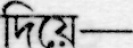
দিয়ে-
